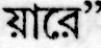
য়ারে”
